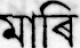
মাৰি
